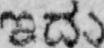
ಇದು
